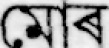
মোৰ
